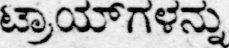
ಟ್ರೌಯ್ ಗಳನ್ನು
